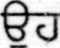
ਉਹ
